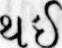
થઈ
